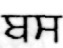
ਬਸ
